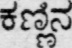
ಕಣ್ಣಿನ
